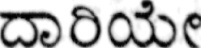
ದಾರಿಯೇ
